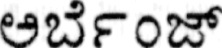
ಅರ್ಬೆಂಜ್
